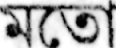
মতো
